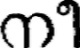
നീ
